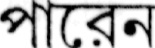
পারেন
